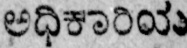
ಅಧಿಕಾರಿಯ
